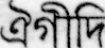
ঐগীদি
